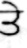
ਤੇ
